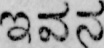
ಇವನ
